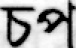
চপ
